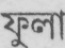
ফুলা
